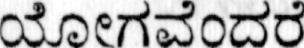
ಯೋಗವೆಂದರೆ
